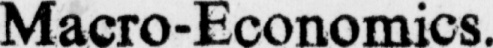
Macro-Economics.
